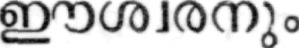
ഈശ്വരനും
